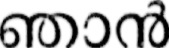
ഞാന്‍
